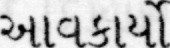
આવકાર્યો
